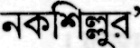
নকশিল্লুর’
